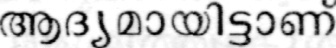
ആദ്യമായിട്ടാണ്
